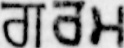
ਗਰਮ
